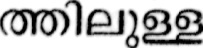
ത്തിലുള്ള
